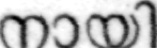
നായി
